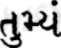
તુમ્યું
